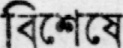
বিশেষে
